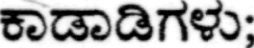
ಕಾಡಾಡಿಗಳು;
